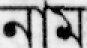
নাম
